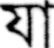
যা
